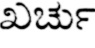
ಖರ್ಚು
